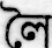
লৈ
